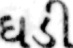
ઘડી
